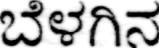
ಬೆಳಗಿನ
